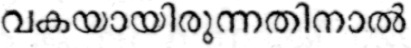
വകയായിരുന്നതിനാല്‍
